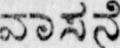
ವಾಸನೆ
